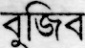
বুজিব
